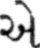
એ
